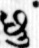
છું
